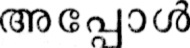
അപ്പോള്‍
